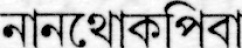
নানথোকপিবা
